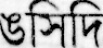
ঙসিদি
